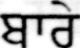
ਬਾਰੇ
